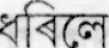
ধৰিলে
